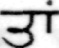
ਤਾਂ
